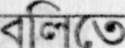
বলিতে
